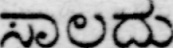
ಸಾಲದು
